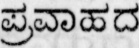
ಪ್ರವಾಹದ
